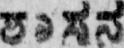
ಶಾಸನ
